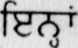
ਇਨ੍ਹਾਂ
